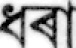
ধৰা
